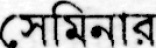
সেমিনার
